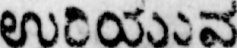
ಉರಿಯುವ
